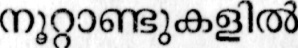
നൂറ്റാണ്ടുകളില്‍
